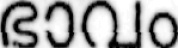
ഭാവം
